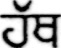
ਹੱਥ
